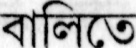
বালিতে
